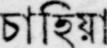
চাহিয়া
